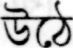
উঠে
